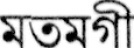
মতমগী
